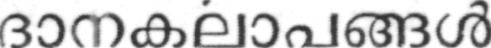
ദാനകലാപങ്ങള്‍
